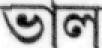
ভাল
